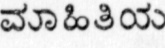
ಮಾಹಿತಿಯ
